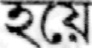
হয়ে
